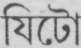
যিটো
